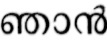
ഞാന്‍
